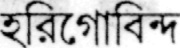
হরিগোবিন্দ
